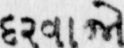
દરવાજો
